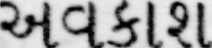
અવકાશ
